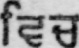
ਵਿਚ
